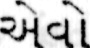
એવો
